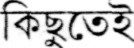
কিছুতেই
